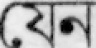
যেন
